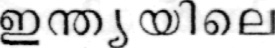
ഇന്ത്യയിലെ
